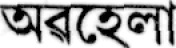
অৱহেলা
